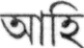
আহি
